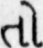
તો
